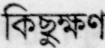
কিছুক্ষণ
